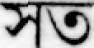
সত
